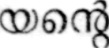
യന്റെ
